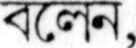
বলেন,
